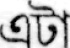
এটা
